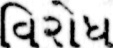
વિરોધ
